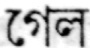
গেল
